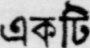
একটি
